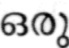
ഒരു
